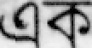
এক
